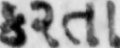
કરતા
